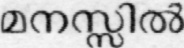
മനസ്സില്‍
